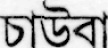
চাউবা
